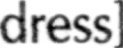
dress]
